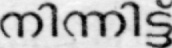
നിന്നിട്ട്
